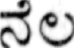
ನೆಲ
